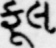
ફૂલ
